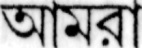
আমরা
